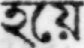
হয়ে
